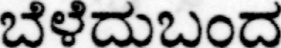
ಬೆಳೆದುಬಂದ
